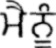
ਮੈਨੂੰ
